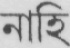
নাহি
